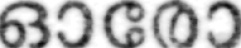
ഓരോ
